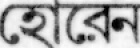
হোরেন
